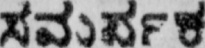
ಸಮರ್ಪಕ
